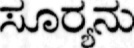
ಸೂರ್‍ಯನು
